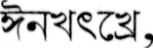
ঈনখৎখ্রে,
